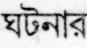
ঘটনার
